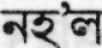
নহ'ল
